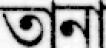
তানা
